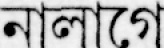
নালাগে
